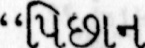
"પિછાન
